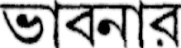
ভাবনার
